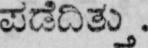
ಪಡೆದಿತ್ತು.
